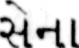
સેના
